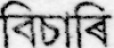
বিচাৰি
